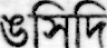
ঙসিদি
